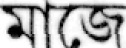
মাজে
